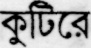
কুটিরে
